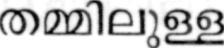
തമ്മിലുള്ള
